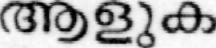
ആളുക
